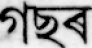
গছৰ
